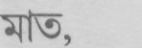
মাত,
